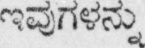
ಇವುಗಳನ್ನು
